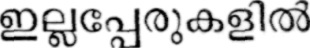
ഇല്ലപ്പേരുകളില്‍
